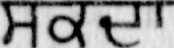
ਸਕਦਾ
